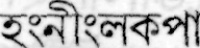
হংনীংলকপা
